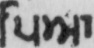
ਪਿਆ
